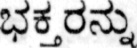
ಭಕ್ತರನ್ನು
